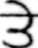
ਤੇ
